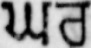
ਘਰ
